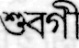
শুবগী
